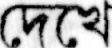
দেখে
